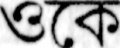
ওকে
